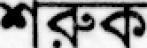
শরুক
